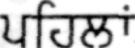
ਪਹਿਲਾਂ
